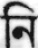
নি
